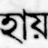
হায়
